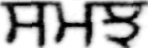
ਸਮਝ
